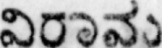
ವಿರಾಮ
